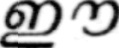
ഈ
